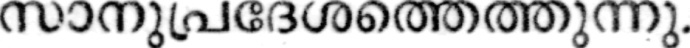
സാനുപ്രദേശത്തെത്തുന്നു.
